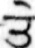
ਤੇ
